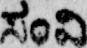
ಸಂವಿ
